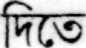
দিতে
